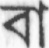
বা
